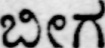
ಬೀಗ
